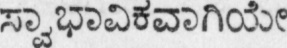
ಸ್ವಾಭಾವಿಕವಾಗಿಯೇ
